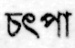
চৎপা
